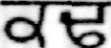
ਕਢ
